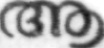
ആ
